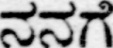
ನನಗೆ
